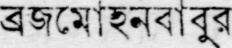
ব্রজমোহনবাবুর
